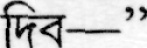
দিব-"
